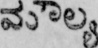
ಮೌಲ್ಯ
